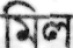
মিল
